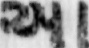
આ
